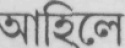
আহিলে
